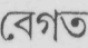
বেগত
